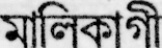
মালিকাগী
